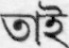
তাই
